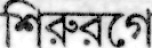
শিরুরগে
